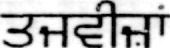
ਤਜਵੀਜ਼ਾਂ
